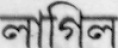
লাগিল
